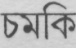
চমকি
